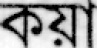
কয়া
